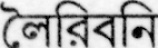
লৈরিবনি
